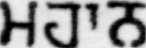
ਮਹਾਨ
